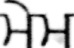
ਮੇਮ
